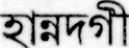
হান্নদগী
